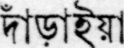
দাঁড়াইয়া
